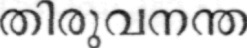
തിരുവനന്ത
